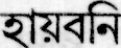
হায়বনি
